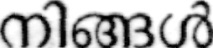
നിങ്ങള്‍
